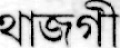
থাজগী
